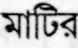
মাটির
